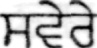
ਸਵੇਰੇ
